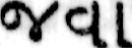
જવા
